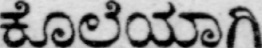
ಕೊಲೆಯಾಗಿ
